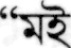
"মই
